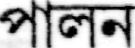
পালন
